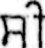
ਸੀ
